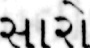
સારો
